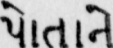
પોતાને
